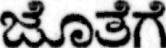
ಜೊತೆಗೆ
